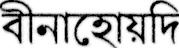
বীনাহোয়দি
